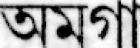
অমগা
